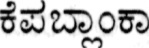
ಕೆಪಬ್ಲಾಂಕಾ
